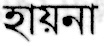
হায়না
